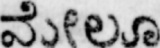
ಮೇಲೂ
